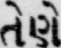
તેણે
